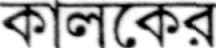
কালকের
